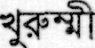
খুরুম্মী
